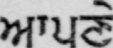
ਆਪਣੇ
